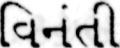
વિનંતી
